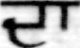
ਦਾ
